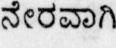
ನೇರವಾಗಿ
